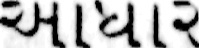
આધાર
